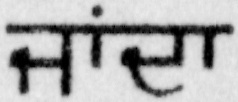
ਜਾਂਦਾ
